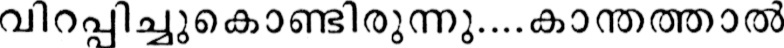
വിറപ്പിച്ചുകൊണ്ടിരുന്നു....കാന്തത്താല്‍
